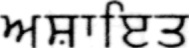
ਅਸ਼ਾਇਤ
